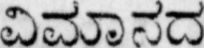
ವಿಮಾನದ
